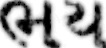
ભય
